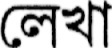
লেখা
